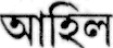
আহিল
